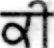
ਕੀ
